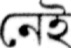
নেই
